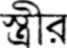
স্ত্রীর
